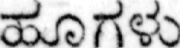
ಹೂಗಳು
